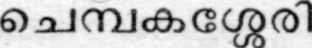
ചെമ്പകശ്ശേരി
